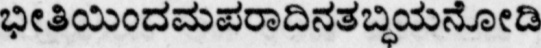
ಭೀತಿಯಿಂದಮಪರಾದಿನತಬ್ಧಿಯನೋಡಿ
